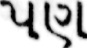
પણ
